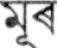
মূৰ
